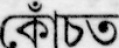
কোঁচত
